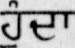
ਹੁੰਦਾ
